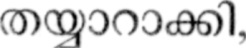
തയ്യാറാക്കി,
